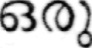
ഒരു
